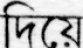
দিয়ে
